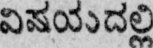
ವಿಷಯದಲ್ಲಿ
